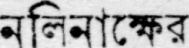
নলিনাক্ষের
